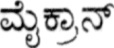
ಮೈಕ್ರಾನ್
